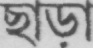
ছাড়া
